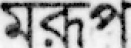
মরূপ
